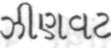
ઝીણવટ
